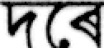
দৰে
